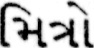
મિત્રો
